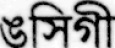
ঙসিগী
